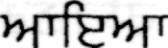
ਆਇਆ
